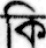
কি
